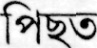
পিছত
